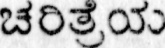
ಚರಿತ್ರೆಯ
